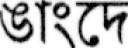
ঙাংদে
